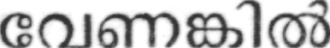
വേണങ്കില്‍
